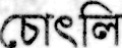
চোৎলি
